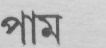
পাম
